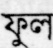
ফুল
